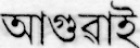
আগুৱাই
